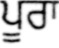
ਪੂਰਾ
